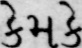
કેમકે
